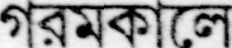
গরমকালে
